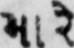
મારે
